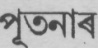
পূতনাৰ
